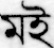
মই
